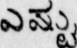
ಎಷ್ಟು
